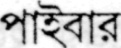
পাইবার
